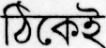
ঠিকেই
